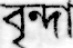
বৃন্দা
